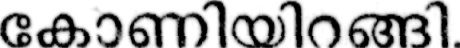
കോണിയിറങ്ങി.
